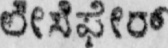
ಲೇಸೆಫೇರ್
